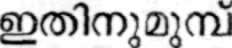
ഇതിനുമുമ്പ്
